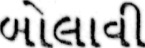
બોલાવી
